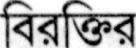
বিরক্তির
